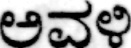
ಅವಳಿ
